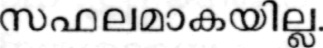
സഫലമാകയില്ല.
